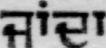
ਜਾਂਦਾ
